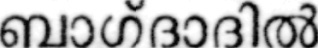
ബാഗ്ദാദില്‍
